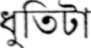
ধুতিটা
